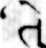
'તે
